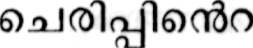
ചെരിപ്പിന്റെ
